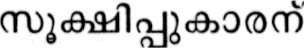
സൂക്ഷിപ്പുകാരന്
